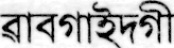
ৱাবগাইদগী
